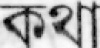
কথা
